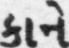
કાને
